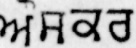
ਅੋਸਕਰ
